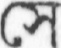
সে
